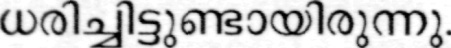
ധരിച്ചിട്ടുണ്ടായിരുന്നു.
